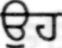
ਉਹ
